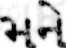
મને
